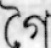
গৈ
